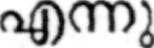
എന്നു
